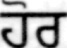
ਹੋਰ
